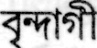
বৃন্দাগী
